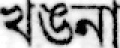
খঙনা
